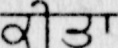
ਕੀਤਾ
